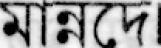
মান্নদে
